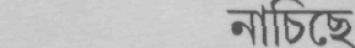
নাচিছে
